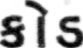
કોડ
